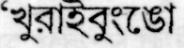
“খুরাইবুংঙো
